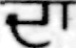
ਦਾ
